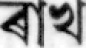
ৰাখ
